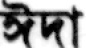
ঈদা
